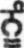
ਨੂੰ
